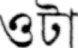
ওটা
